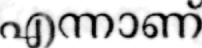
എന്നാണ്
